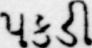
પકડી
